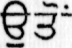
ਉਤੋਂ
